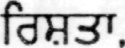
ਰਿਸ਼ਤਾ,
